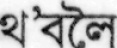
থ'বলৈ
